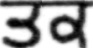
ਤਕ
